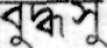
বুদ্ধসু
